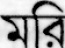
মরি
